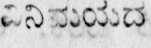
ವಿನಿಮಯದ
